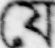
যে
